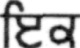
ਇਕ
